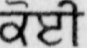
ਕੋਈ
